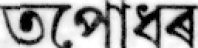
তপোধৰ
